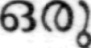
ഒരു
